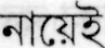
নায়েই
